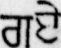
ਗਏ
